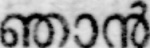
ഞാന്‍
